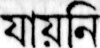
যায়নি
